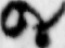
જ
